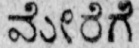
ಮೇರೆಗೆ
